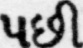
પછી
